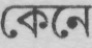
কেনে
